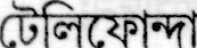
টেলিফোন্দা
